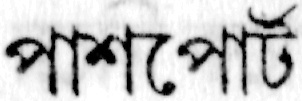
পাশপোর্ট
